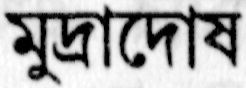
মুদ্রাদোষ
